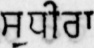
ਸੁਧੀਰਾ
